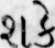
શકે
